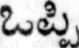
ಒಪ್ಪಿ
